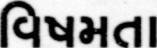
વિષમતા
